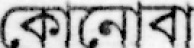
কোনোবা
